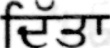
ਦਿੱਤਾ
